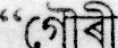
"গৌৰী
